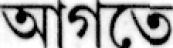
আগতে
